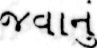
જવાનું
